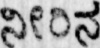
ನೀರಿನ
